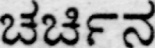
ಚರ್ಚಿನ
